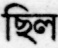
ছিল
